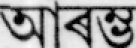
আৰম্ভ
